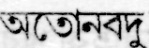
অতোনবদু
